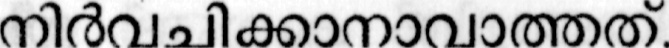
നിര്‍വചിക്കാനാവാത്തത്.
